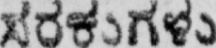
ಸರಕುಗಳು
